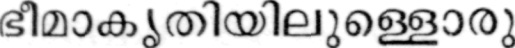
ഭീമാകൃതിയിലുള്ളൊരു
